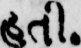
હતી.
